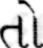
તો
